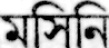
মসিনি
